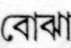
বোঝা
